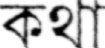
কথা
